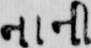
નાની
